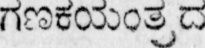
ಗಣಕಯಂತ್ರದ
